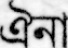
ঐনা
